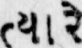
ત્યારે
